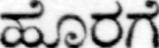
ಹೊರಗೆ
